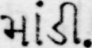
માંડી.
